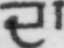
ਦਾ
